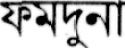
ফমদুনা
